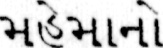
મહેમાનો
